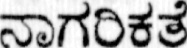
ನಾಗರಿಕತೆ
